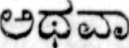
ಅಥವಾ
